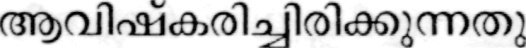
ആവിഷ്കരിച്ചിരിക്കുന്നതു
